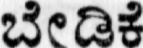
ಬೇಡಿಕೆ
